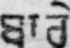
ਬਾਰੇ
